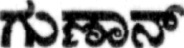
ಗುಣಾನ್
